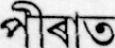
পীৰাত
